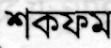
শকফম
